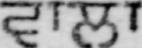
ਵਾਲਾ
